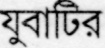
যুবাটির
